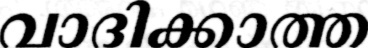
വാദിക്കാത്ത
